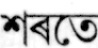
শৰতে
